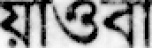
য়াওবা
